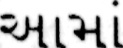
આમાં
